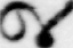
જ
